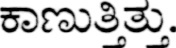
ಕಾಣುತ್ತಿತ್ತು.
